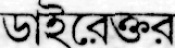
ডাইরেক্তর
